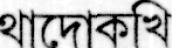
থাদোকখি
